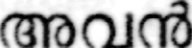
അവന്‍
